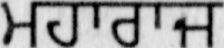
ਮਹਾਰਾਜ
